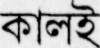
কালই
